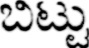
ಬಿಟ್ಟು
